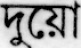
দুয়ো
